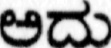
ಅದು
